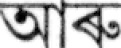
আৰু
